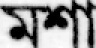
মশা
